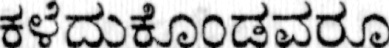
ಕಳೆದುಕೊಂಡವರೂ
